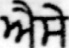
ਐਸੇ
